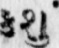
કશું
